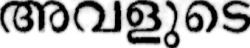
അവളുടെ
